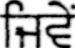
ਜਿਵੇਂ
